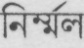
নিৰ্ম্মল
